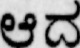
ಆದ
